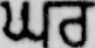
ਘਰ
